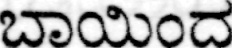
ಬಾಯಿಂದ
